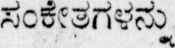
ಸಂಕೇತಗಳನ್ನು
